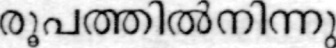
രൂപത്തില്‍നിന്നു
